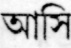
আসি
